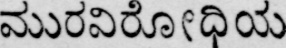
ಮುರವಿರೋಧಿಯ
